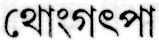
থোংগৎপা
